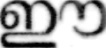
ഈ
